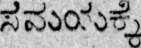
ಸಮಯಕ್ಕೆ
